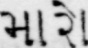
મારો
